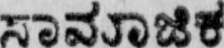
ಸಾಮಾಜಿಕ
